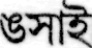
ঙসাই
